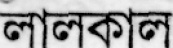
লালকাল
